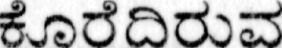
ಕೊರೆದಿರುವ
